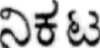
ನಿಕಟ
